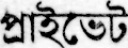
প্রাইভেট
